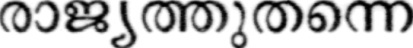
രാജ്യത്തുതന്നെ
